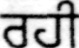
ਰਹੀ
